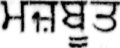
ਮਜ਼ਬੂਤ
